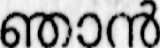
ഞാന്‍
